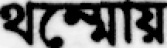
থম্মোয়
